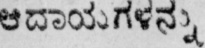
ಆದಾಯಗಳನ್ನು
